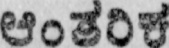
ಆಂತರಿಕ
